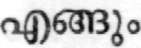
എങ്ങും
